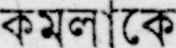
কমলাকে
